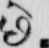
છે.
